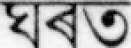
ঘৰত
